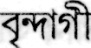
বৃন্দাগী
